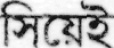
সিয়েই
